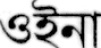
ওইনা
